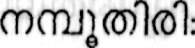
നമ്പൂതിരി:
